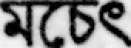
মচেৎ
